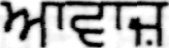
ਆਵਾਜ਼
